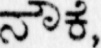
ನೌಕೆ,
